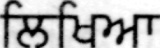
ਲਿਖਿਆ
